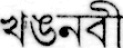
খঙনবী
